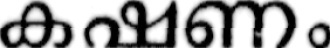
കഷണം
